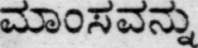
ಮಾಂಸವನ್ನು
